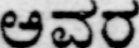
ಅವರ
